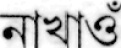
নাখাওঁ
